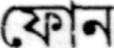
ফোন
